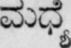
ಮಧ್ಯೆ
